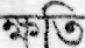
ক্ষতি
